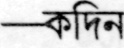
–কদিন
